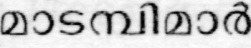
മാടമ്പിമാര്‍
